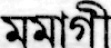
মমাগী
